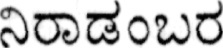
ನಿರಾಡಂಬರ
